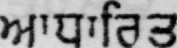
ਆਧਾਰਿਤ
